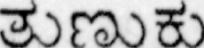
ತುಣುಕು
